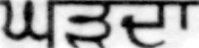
ਘੜਦਾ
